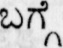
ಬಗ್ಗೆ
